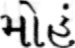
મોહં
